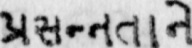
પ્રસન્નતાને
